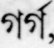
গর্গ,
